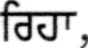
ਰਿਹਾ,
